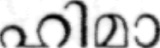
ഹിമാ
